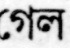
গেল
